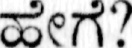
ಹೇಗೆ?
